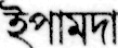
ইপামদা
